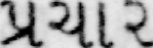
પ્રચાર
